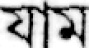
যাম
